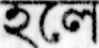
হলে
